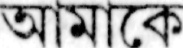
আমাকে
